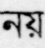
নয়
